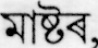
মাষ্টৰ,
